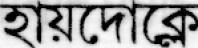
হায়দোক্লে
